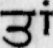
ਤਾਂ
